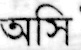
অসি
